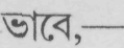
ভাবে,-
